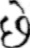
છે
